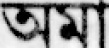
অমা
